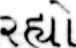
રહ્યો
